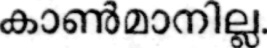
കാണ്‍മാനില്ല.
